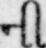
ની
